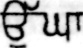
ਉੱਘਾ
